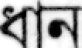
ধান
